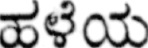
ಹಳೆಯ
